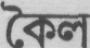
কৈল
